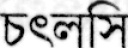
চৎলসি
